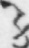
કે
